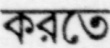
করতে
